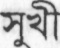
সুখী
